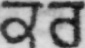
ਕਰ
